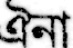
ঐনা
